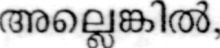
അല്ലെങ്കില്‍,
